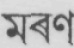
মৰণ
